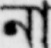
না
